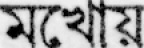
মখোয়
